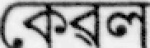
কেৱল
